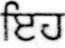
ਇਹ
